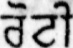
ਰੋਟੀ
